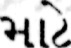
માટે
